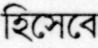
হিসেবে
